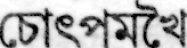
চোৎপমখৈ
